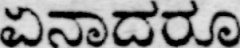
ಏನಾದರೂ
